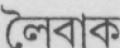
লৈবাক
